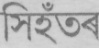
সিহঁতৰ
